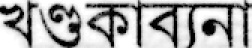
খণ্ডকাব্যনা
